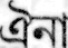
ঐনা
